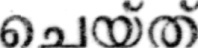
ചെയ്ത്
